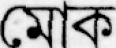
মোক
